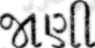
જાણી
